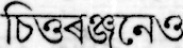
চিত্তৰঞ্জনেও
